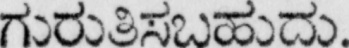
ಗುರುತಿಸಬಹುದು.
